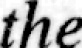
the
